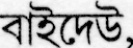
বাইদেউ,
